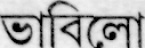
ভাবিলো
